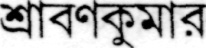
শ্রাবণকুমার
